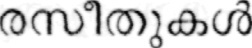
രസീതുകള്‍
